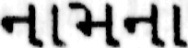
નામના
